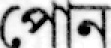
পোন
